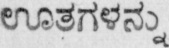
ಊತಗಳನ್ನು
